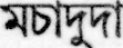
মচাদুদা
